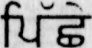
ਪਿੱਛੇ
